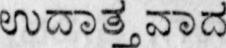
ಉದಾತ್ತವಾದ
